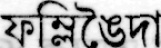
ফম্লিঙৈদা
